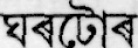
ঘৰটোৰ
